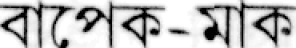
বাপেক-মাক
